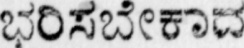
ಭರಿಸಬೇಕಾದ
